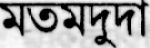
মতমদুদা
